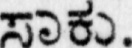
ಸಾಕು.
